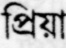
প্রিয়া
